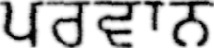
ਪਰਵਾਨ
